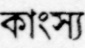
কাংস্য
